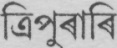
ত্ৰিপুৰাৰি
